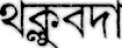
থক্লুবদা
